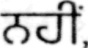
ਨਹੀਂ,
